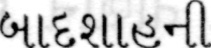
બાદશાહની
